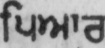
ਪਿਆਰ
